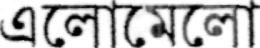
এলোমেলো
